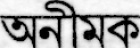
অনীমক
